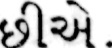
છીએ.
